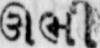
ઊભી
